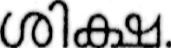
ശിക്ഷ.
